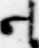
ન
